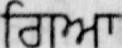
ਗਿਆ
